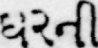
ઘરની
